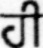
ਹੀ
